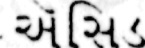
ઍસિડ
